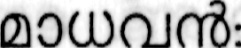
മാധവന്‍:
